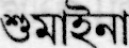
শুমাইনা
